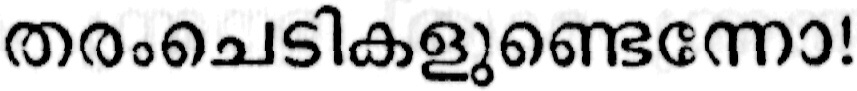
തരംചെടികളുണ്ടെന്നോ!
